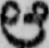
ಆ
